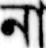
না
